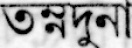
তম্লদুনা
